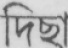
দিছা
